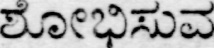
ಶೋಭಿಸುವ
